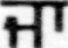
ਜਾ
